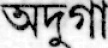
অদুগা
